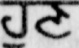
ਹੁਣ
